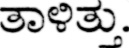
ತಾಳಿತ್ತು.
